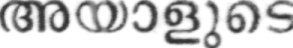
അയാളുടെ
